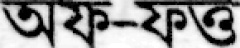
অফ-ফত্ত
